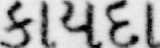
કાયદા
